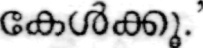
കേള്‍ക്കൂ.’
